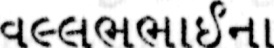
વલ્લભભાઈના
